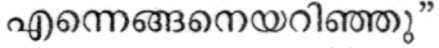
എന്നെങ്ങനെയറിഞ്ഞു”
